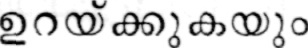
ഉറയ്ക്കുകയും
